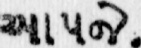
આપજે,
